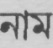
নাম
